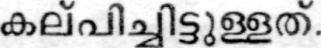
കല്പിച്ചിട്ടുള്ളത്.
